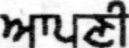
ਆਪਣੀ
